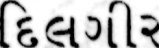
દિલગીર
